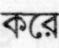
করে
